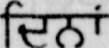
ਦਿਨਾਂ
